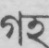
গহ
